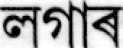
লগাৰ
